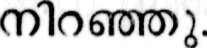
നിറഞ്ഞു.
